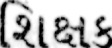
શિક્ષક
